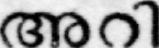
അറി
